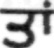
ਤਾਂ
